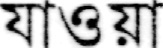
যাওয়া
